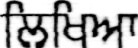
ਲਿਖਿਆ
